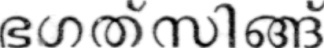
ഭഗത്സിങ്ങ്
